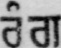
ਰੰਗ
